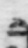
ਹੈ
